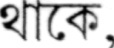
থাকে,
